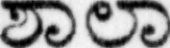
ಶಾಲಾ
